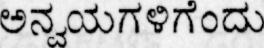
ಅನ್ವಯಗಳಿಗೆಂದು
